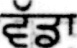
ਵੱਡਾ
